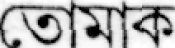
তোমাক
